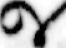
જ
